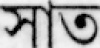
সাত
